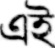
এই
